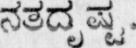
ನತದೃಷ್ಟ.
